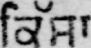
ਕਿੱਸਾ
